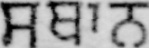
ਸਥਾਨ
